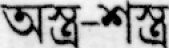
অস্ত্র-শস্ত্র
